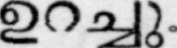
ഉറച്ചു.
